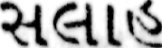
સલાહ
